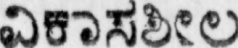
ವಿಕಾಸಶೀಲ
